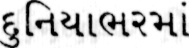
દુનિયાભરમાં
